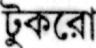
টুকরো
